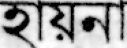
হায়না
